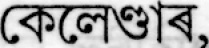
কেলেণ্ডাৰ,
